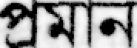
প্রমান
